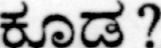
ಕೂಡ?
